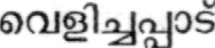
വെളിച്ചപ്പാട്
